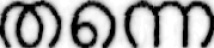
തന്നെ
